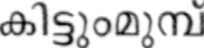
കിട്ടുംമുമ്പ്
